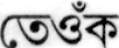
তেওঁক
